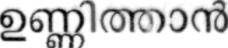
ഉണ്ണിത്താന്‍
